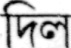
দিল
